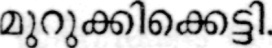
മുറുക്കിക്കെട്ടി.
